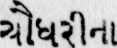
ચૌધરીના
